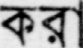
করা
